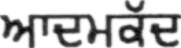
ਆਦਮਕੱਦ
